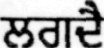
ਲਗਦੈ
